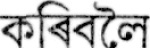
কৰিবলৈ
